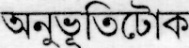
অনুভূতিটোক
